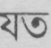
যত
